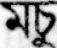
মচু
